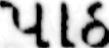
પાઠ
